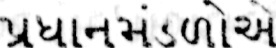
પ્રધાનમંડળોએ
